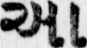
આ
